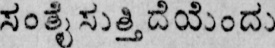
ಸಂತೈಸುತ್ತಿದೆಯೆಂದು
